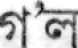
গ'ল
